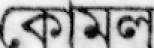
কোমল
